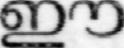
ഈ
